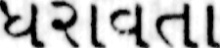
ધરાવતા
